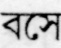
বসে
